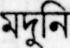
মদুনি
